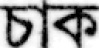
চাক
